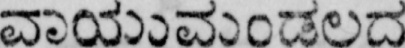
ವಾಯುಮಂಡಲದ
